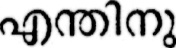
എന്തിനു
